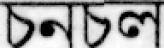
চনচল
